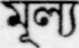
মূল্য
